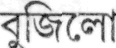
বুজিলো
